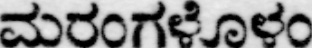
ಮರಂಗಳೊಳಂ
